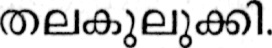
തലകുലുക്കി.
